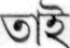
তাই
